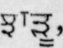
ਝਾੜੂ,
